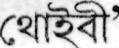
থোইবী’
